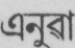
এনুৱা
